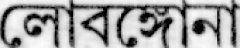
লোবঙ্গোনা
